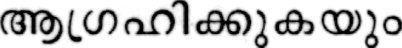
ആഗ്രഹിക്കുകയും
